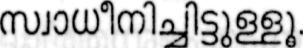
സ്വാധീനിച്ചിട്ടുള്ളൂ.
